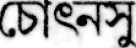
চোৎনসু
